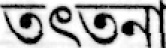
তৎতনা
